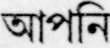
আপনি
